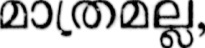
മാത്രമല്ല,
